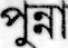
পুন্না
